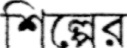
শিল্পের
